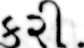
કરી.
